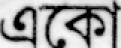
একো
